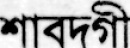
শাবদগী
